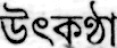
উৎকুণ্ঠা
